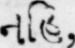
નહિ,
